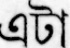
এটা
